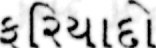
ફરિયાદો
